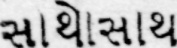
સાથોસાથ
